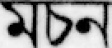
মচন
